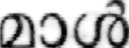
മാള്‍
